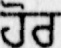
ਹੋਰ
